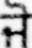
ਜੋ
